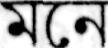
মনে
